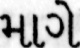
માગે
